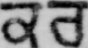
ਕਰ
